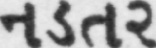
નડતર
